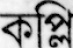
কপ্লি
